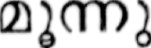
മൂന്നു
